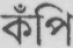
কঁপি
